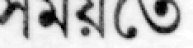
সময়তে
